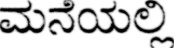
ಮನೆಯಲ್ಲಿ
